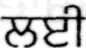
ਲਈ
